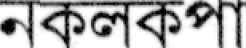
নকলকপা
